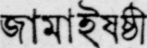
জামাইষষ্ঠী
